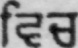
ਵਿਚ
